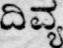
ದಿವ್ಯ
